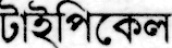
টাইপিকেল
